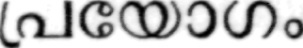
പ്രയോഗം
